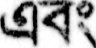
এবং
